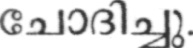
ചോദിച്ചു.
